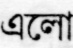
এলো
